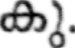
കു.
